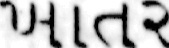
ખાતર
